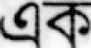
এক
